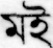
মই
